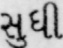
સુધી
